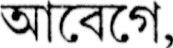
আবেগে,
